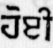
ਹੋਈ
